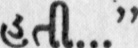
હતી...”
